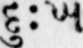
દુઃખ
